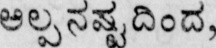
ಅಲ್ಪನಷ್ಟದಿಂದ,
